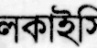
ইশূনুপী
